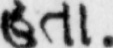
હતા.
